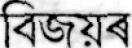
বিজয়ৰ
